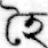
হৈ
